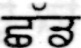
ਛੱਡ
